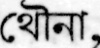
থৌনা,
